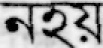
নহয়
